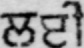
ਲਈ
